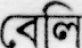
বেলি
